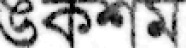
ঙকশম
